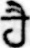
ਹੈ
